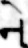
ને
